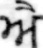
ਐ
